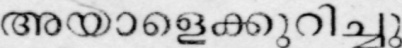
അയാളെക്കുറിച്ചു
